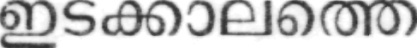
ഇടക്കാലത്തെ
